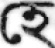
হে
